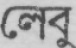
লেবু
